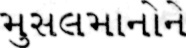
મુસલમાનોને
